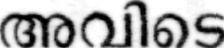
അവിടെ
